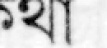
কথা
